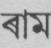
ৰাম
